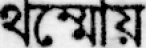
থম্মোয়
